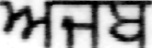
ਅਜਬ
